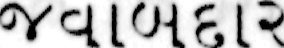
જવાબદાર
